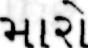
મારો
